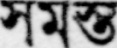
সমস্ত
